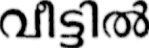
വീട്ടില്‍
